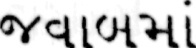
જવાબમાં
